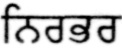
ਨਿਰਭਰ
